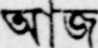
আজ
